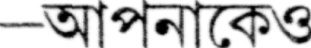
-আপনাকেও
